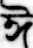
ঈ
